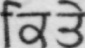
ਕਿਤੇ
